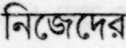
নিজেদের
